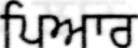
ਪਿਆਰ
